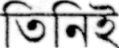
তিনিই
